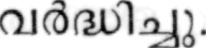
വര്‍ദ്ധിച്ചു.
